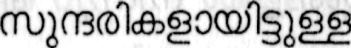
സുന്ദരികളായിട്ടുള്ള
